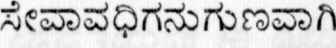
ಸೇವಾವಧಿಗನುಗುಣವಾಗಿ
